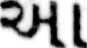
આ
